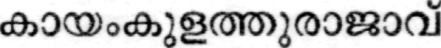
കായംകുളത്തുരാജാവ്
